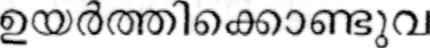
ഉയര്‍ത്തിക്കൊണ്ടുവ
